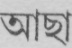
আছা
